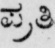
ಪ್ರತಿ
